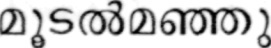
മൂടല്‍മഞ്ഞു
